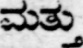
ಮತ್ತು
